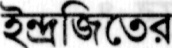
ইন্দ্রজিতের
